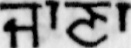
ਜਾਣਾ
